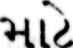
માટે
